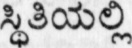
ಸ್ಥಿತಿಯಲ್ಲಿ
